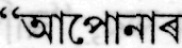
"আপোনাৰ
